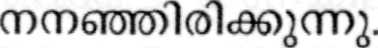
നനഞ്ഞിരിക്കുന്നു.
